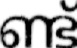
ണ്ട്
